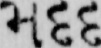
મદદ
